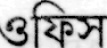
ওফিস
